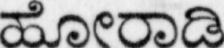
ಹೋರಾಡಿ
